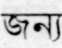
জন্য
